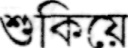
শুকিয়ে
